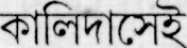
কালিদাসেই
